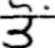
ਤੋਂ
